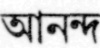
আনন্দ
